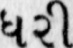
ધરી
